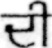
ਦੀ
